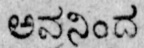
ಅವನಿಂದ
